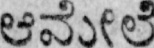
ಆಮೇಲೆ
